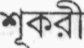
শূকরী
